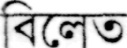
বিলেত
